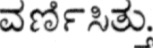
ವರ್ಣಿಸಿತ್ತು.
